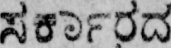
ಸರ್ಕಾರದ
